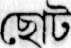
ছোট
